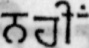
ਨਹੀਂ
